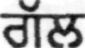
ਗੱਲ
